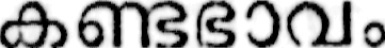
കണ്ടഭാവം
